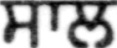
ਸਾਲ
